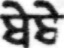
ਬੇਬੇ
